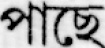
পাছে
